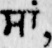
ਸਾਂ,
